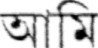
আমি
